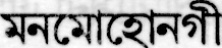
মনমোহোনগী
